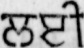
ਲਈ
